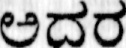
ಅದರ
